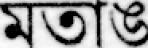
মতাঙ
